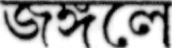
জঙ্গলে
